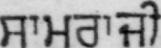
ਸਾਮਰਾਜੀ
